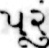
પૂરું
